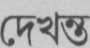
দেখন্ত
